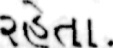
રહેતા.
